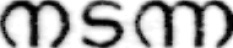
നടന്ന
